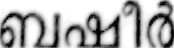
ബഷീര്‍
